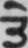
ਤੇ
